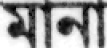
মানা
